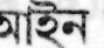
আইন
